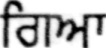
ਗਿਆ
